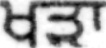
ਖੜਾ
